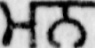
ਮਨ
